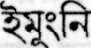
ইমুংনি
